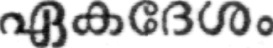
ഏകദേശം
